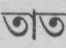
তাত
